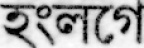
হংলগে
